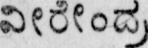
ವೀರೇಂದ್ರ
